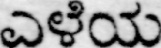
ಎಳೆಯ
